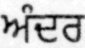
ਅੰਦਰ
